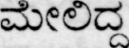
ಮೇಲಿದ್ದ
